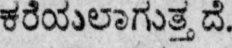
ಕರೆಯಲಾಗುತ್ತದೆ.
